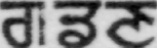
ਗਡਣ
